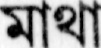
মাথা
